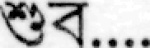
শুব....
